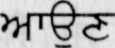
ਆਉਣ
